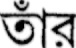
তাঁর
